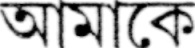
আমাকে
